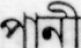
পানী
